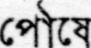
পৌষে
